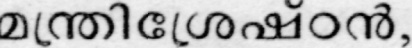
മന്ത്രിശ്രേഷ്ഠന്‍,
